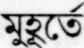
মুহূর্তে
